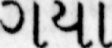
ગયા
